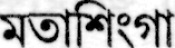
মতাশিংগা
